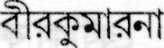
বীরকুমারনা
